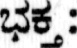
ಭಕ್ತ:
